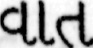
વાત
